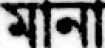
মানা
